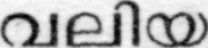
വലിയ
